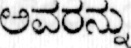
ಅವರನ್ನು
